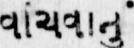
વાંચવાનું
